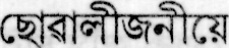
ছোৱালীজনীয়ে
